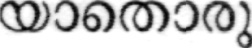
യാതൊരു
